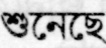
শুনেছে
